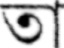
তা
